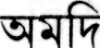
অমদি
